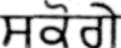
ਸਕੋਗੇ
